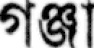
গঞ্জা
